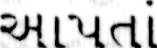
આપતાં
